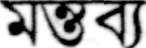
মন্তব্য
